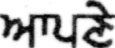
ਆਪਣੇ
